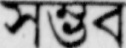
সম্ভব
